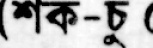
(শক-চু
